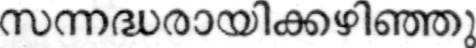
സന്നദ്ധരായിക്കഴിഞ്ഞു
